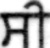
ਸੀ
